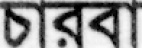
চারবা
